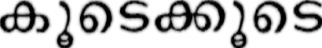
കൂടെക്കൂടെ
